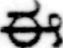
ಈ
